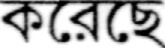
করেছে
